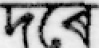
দৰে
